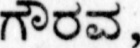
ಗೌರವ,
